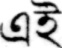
এই
